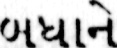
બધાને
